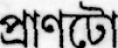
প্রাণটো
